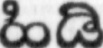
ಹಿಡಿ
